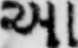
આ
